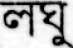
লঘু
